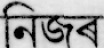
নিজৰ
